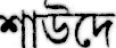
শাউদে
